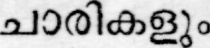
ചാരികളും
